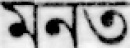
মনত
